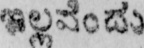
ಇಲ್ಲವೆಂದು
